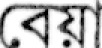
বেয়া
